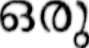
ഒരു
